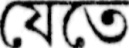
যেতে
